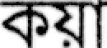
কয়া
